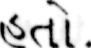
હતો.
